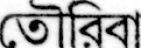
তৌরিবা
